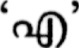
‘എ’
